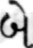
બે
